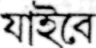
যাইবে
